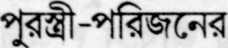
পুরস্ত্রী-পরিজনের
